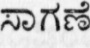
ಸಾಗಣೆ
